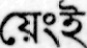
য়েংই
